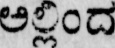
ಅಲ್ಲಿಂದ
